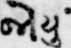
જોયું
